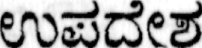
ಉಪದೇಶ
